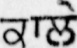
ਕਾਲੇ
